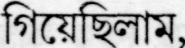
গিয়েছিলাম,
